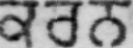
ਕਰਨ
